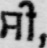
ਸੀ,
